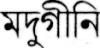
মদুদগীনি
